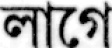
লাগে
